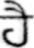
ਹੈ
